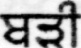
ਬੜੀ
